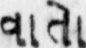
વાતો
